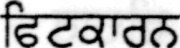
ਫਿਟਕਾਰਨ
